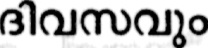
ദിവസവും
